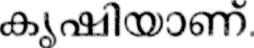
കൃഷിയാണ്.
